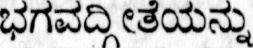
ಭಗವದ್ಗೀತೆಯನ್ನು
